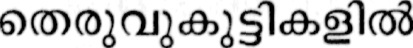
തെരുവുകുട്ടികളില്‍
